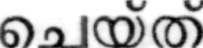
ചെയ്ത്
